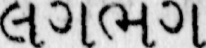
લગભગ
